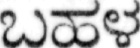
ಬಹಳ
